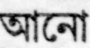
আনো
